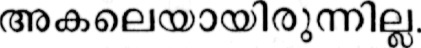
അകലെയായിരുന്നില്ല.
